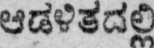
ಆಡಳಿತದಲ್ಲಿ
